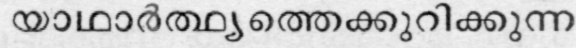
യാഥാര്‍ത്ഥ്യത്തെക്കുറിക്കുന്ന
